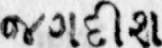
જગદીશ
